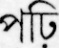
পঢ়ি
